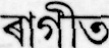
ৰাগীত
